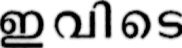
ഇവിടെ
